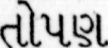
તોપણ
